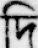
দি
